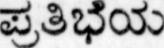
ಪ್ರತಿಭೆಯ
